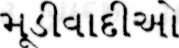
મૂડીવાદીઓ
